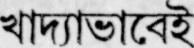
খাদ্যাভাবেই
